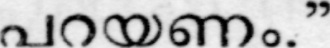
പറയണം.”
